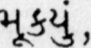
મૂકયું,
